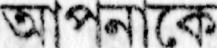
আপনাকে
